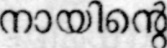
നായിന്റെ
